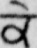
ਕੇ
